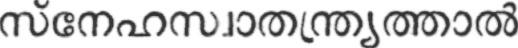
സ്നേഹസ്വാതന്ത്ര്യത്താല്‍
